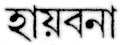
হায়বনা
